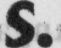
S.
